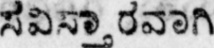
ಸವಿಸ್ತಾರವಾಗಿ
